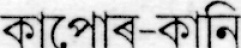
কাপোৰ-কানি
